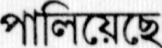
পালিয়েছে
